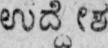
ಉದ್ದೇಶ
